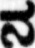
ನ
